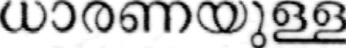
ധാരണയുള്ള
